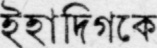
ইহাদিগকে
